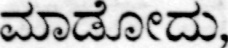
ಮಾಡೋದು,
